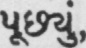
પૂછ્યું,
